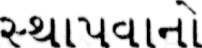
સ્થાપવાનો
